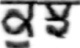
ਕੁਝ
